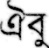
ঐবু
